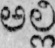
ಅಲ್ಲಿ
